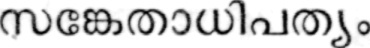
സങ്കേതാധിപത്യം
